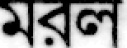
মরল
